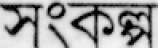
সংকল্প
